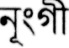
নূংগী
